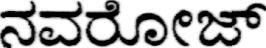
ನವರೋಜ್
